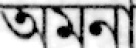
অমনা
